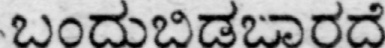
ಬಂದುಬಿಡಬಾರದೆ
